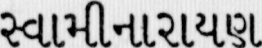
સ્વામીનારાયણ
